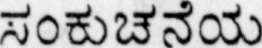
ಸಂಕುಚನೆಯ
